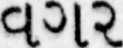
વગર
